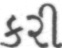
કરી
